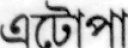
এটোপা
